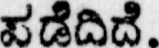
ಪಡಿದಿದೆ.
